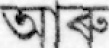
আৰু
